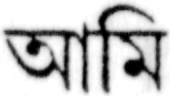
আমি
